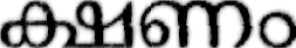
ക്ഷണം
